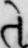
તે
